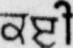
ਕਈ
